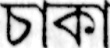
চাকা
